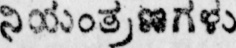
ನಿಯಂತ್ರಣಗಳು
